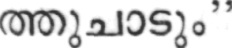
ത്തുചാടും"
